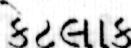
કેટલાક
